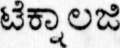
ಟೆಕ್ನಾಲಜಿ
